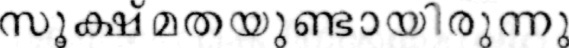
സൂക്ഷ്മതയുണ്ടായിരുന്നു
